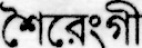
শৈরেংগী
